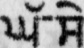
ਘੱਸੇ
